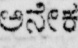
ಅನೇಕ
